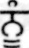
ਨੂੰ
